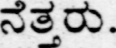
ನೆತ್ತರು.
